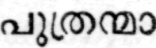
പുത്രന്മാ
